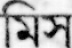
মিস
